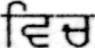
ਵਿਚ
